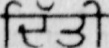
ਦਿੱਤੀ
